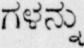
ಗಳನ್ನು
